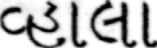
વ્હાલા
